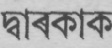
দ্বাৰকাক
